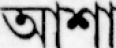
আশা
